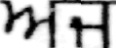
ਅਜ
